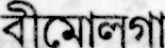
বীমোলগা
